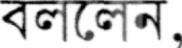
বললেন,
